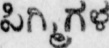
ಪಿಗ್ಮಿಗಳ
